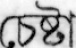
চেষ্টা
